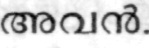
അവന്‍.
